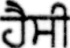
ਹੈਸੀ
